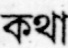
কথা
